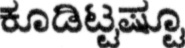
ಕೂಡಿಟ್ಟಷ್ಟೂ
